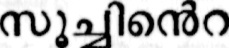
സൂച്ചിന്റെ
